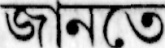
জানতে
